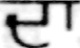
ਦਾ
